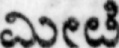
ಮೀೞ
